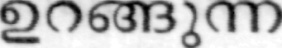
ഉറങ്ങുന്ന
